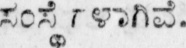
ಸಂಸ್ಥೆಗಳಾಗಿವೆ.
